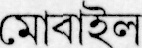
মোবাইল
